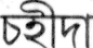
চহীদা
